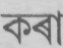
কৰা
